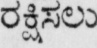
ರಕ್ಷಿಸಲು
